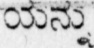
ಯನ್ನು
